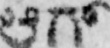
ಆಗ್
